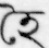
হৈ
